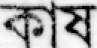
কাষ
